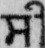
ਸੀ
